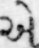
એ
